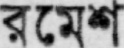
রমেশ
